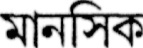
মানসিক
